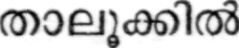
താലൂക്കില്‍
